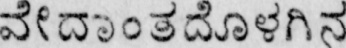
ವೇದಾಂತದೊಳಗಿನ
